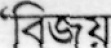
'বিজয়
